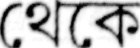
থেকে
